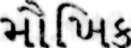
મૌખિક
